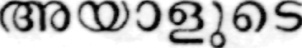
അയാളുടെ
